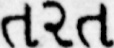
તરત
